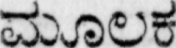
ಮೂಲಕ
